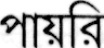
পায়রি
